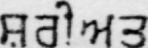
ਸ਼ਰੀਅਤ
